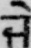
ਜੇ
